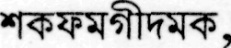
শকফমগীদমক,
